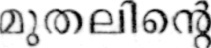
മുതലിന്റെ
